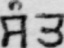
ਸੰਤ
